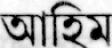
আহিম
